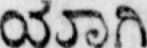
ಯಾಗಿ
